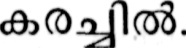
കരച്ചില്‍.
